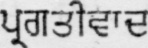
ਪ੍ਰਗਤੀਵਾਦ
